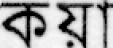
কয়া
